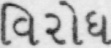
વિરોધ
